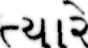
ત્યારે
